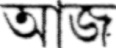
আজ
